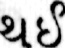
થઈ
